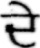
ਦੇ
